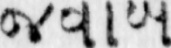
જવાબ
